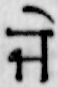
ਜੇ
